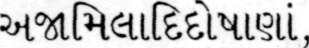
અજામિલાદિદોષાણાં
